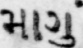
માગું
